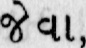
જેવા,
